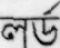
লর্ড
